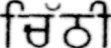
ਚਿੱਠੀ
